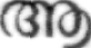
ആ
